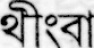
থীংবা
